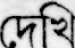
দেখি
